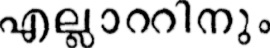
എല്ലാററിനും
